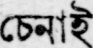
চেনাই
